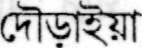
দৌড়াইয়া
